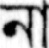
না
